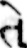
તે
